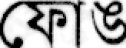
ফোঙ
